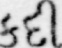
કદી
